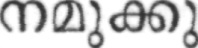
നമുക്കു
